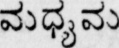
ಮಧ್ಯಮ
